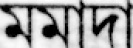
মমাদা
